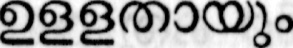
ഉളളതായും
